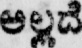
ಅಲ್ಲದೆ
